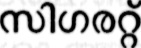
സിഗരറ്റ്
